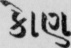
કોણ
